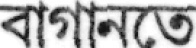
বাগানতে
